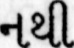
નથી
